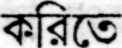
করিতে
